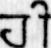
ਹੀ
